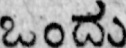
ಒಂದು
